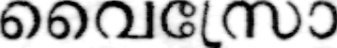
വൈസ്രോ
